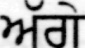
ਅੱਗੇ
